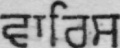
ਵਾਰਿਸ
